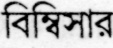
বিম্বিসার
